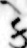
કે
